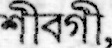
শীবগী,
